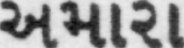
અમારા
